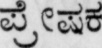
ಪ್ರೇಷಕ
